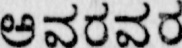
ಅವರವರ
